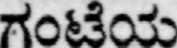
ಗಂಟೆಯ
